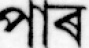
পাৰ
